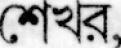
শেখর,
